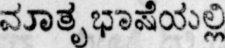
ಮಾತೃಭಾಷೆಯಲ್ಲಿ
